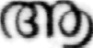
ആ
